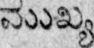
ಮುಖ್ಯ
